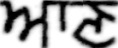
ਆਣ
